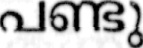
പണ്ടു
